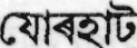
যোৰহাট
